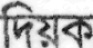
দিয়ক
